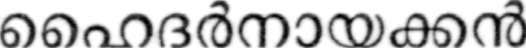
ഹൈദര്‍നായക്കന്‍
